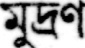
মুদ্রণ
